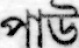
পাউ
